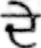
ਦੇ
